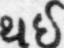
થઈ
